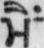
ਮੈਂ
